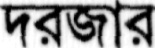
দরজার
